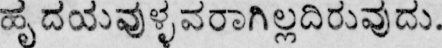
ಹೃದಯವುಳ್ಳವರಾಗಿಲ್ಲದಿರುವುದು.
